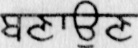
ਬਣਾਉਣ
